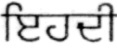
ਇਹਦੀ
